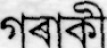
গৰাকী
